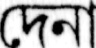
দেনা
